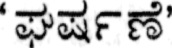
'ಘರ್ಷಣೆ'
